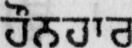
ਹੌਨਹਾਰ
